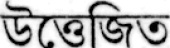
উত্তেজিত
